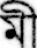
মী
